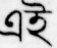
এই
